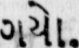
ગયો.
